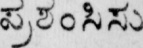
ಪ್ರಶಂಸಿಸು
